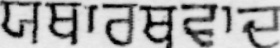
ਯਥਾਰਥਵਾਦ
